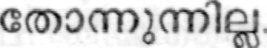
തോന്നുന്നില്ല.
